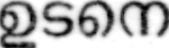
ഉടനെ
